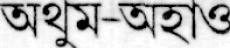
অথুম-অহাও
